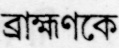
ব্রাহ্মণকে
